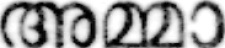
അമ്മാ
